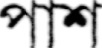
পাশ
